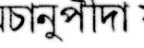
মচানুপীদা
